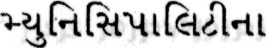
મ્યુનિસિપાલિટીના
